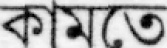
কামতে
